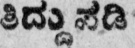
ತಿದ್ದುಪಡಿ
